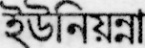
ইউনিয়ন্না
